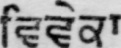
ਵਿਵੇਕਾ
